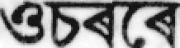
ওচৰৰে
